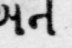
અને
